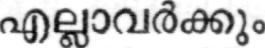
എല്ലാവര്‍ക്കും
